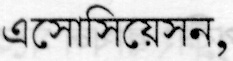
এসোসিয়েসন,
